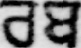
ਰਬ
